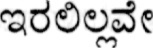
ಇರಲಿಲ್ಲವೇ
